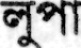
লুপা
